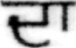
ਦਾ
